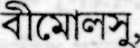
বীমোলসু,
